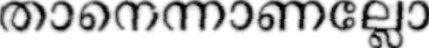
താനെന്നാണല്ലോ
